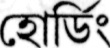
হোর্ডিং
